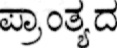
ಪ್ರಾಂತ್ಯದ
